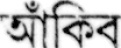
আঁকিব
